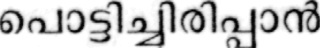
പൊട്ടിച്ചിരിപ്പാന്‍
